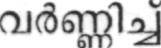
വര്‍ണ്ണിച്ച്
